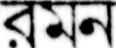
রমন
